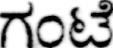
ಗಂಟೆ
